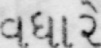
વધારે
